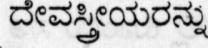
ದೇವಸ್ತ್ರೀಯರನ್ನು
